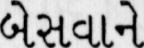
બેસવાને
